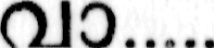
വാ...
